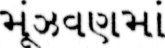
મૂંઝવણમાં
